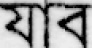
যাব
